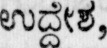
ಉದ್ದೇಶ,
